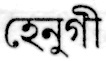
হেনুগী
